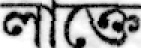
লাক্তে
